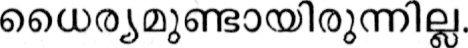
ധൈര്യമുണ്ടായിരുന്നില്ല.
